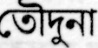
তৌদুনা
